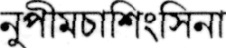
নুপীমচাশিংসিনা
